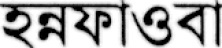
হন্নফাওবা
